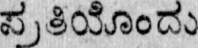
ಪ್ರತಿಯೊಂದು
